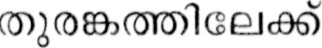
തുരങ്കത്തിലേക്ക്
